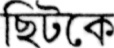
ছিটকে
